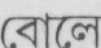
বোলে
